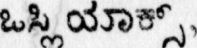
ಒಸ್ಲಿಯಾಕ್ಸ್,
